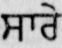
ਸਾਰੇ
